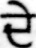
ਦੇ
